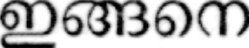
ഇങ്ങനെ
